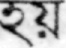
হয়
